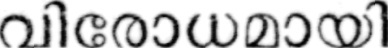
വിരോധമായി
